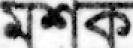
মশক
